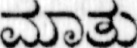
ಮಾತು
